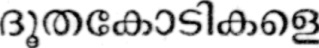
ദൂതകോടികളെ
